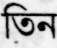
তিন
